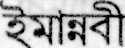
ইমান্নবী
